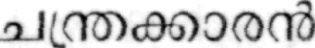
ചന്ത്രക്കാരന്‍
